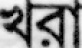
খরা
